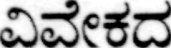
ವಿವೇಕದ
